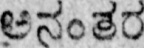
ಅನಂತರ
